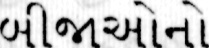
બીજાઓનો
